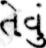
તેવું
